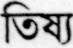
তিষ্য
